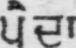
ਪੈਦਾ
